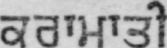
ਕਰਾਮਾਤੀ
